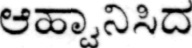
ಆಹ್ವಾನಿಸಿದ
